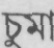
চুমা
